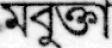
মবুক্তা
